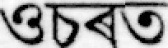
ওচৰত
